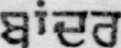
ਬਾਂਦਰ
